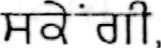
ਸਕੇਂਗੀ,
